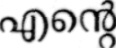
എന്റെ
